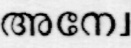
അന്വേ
